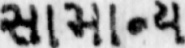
સામાન્ય
